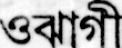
ওঝাগী
